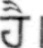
ਹੈ।
